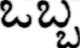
ಒಬ್ಬ
